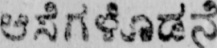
ಆಸೆಗಳೊಡನೆ
